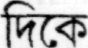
দিকে
